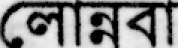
লোন্নবা
